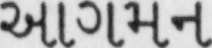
આગમન
